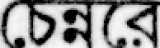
চেন্নরে
